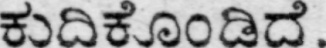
ಕುದಿಕೊಂಡಿದೆ.
